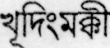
খূদিংমক্কী
